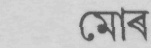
মোৰ
